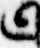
এ
